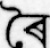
ৰৈ
